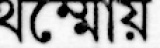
থম্মোয়
